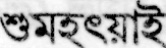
শুমহৎয়াই
